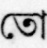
তো
